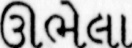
ઊભેલા
